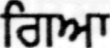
ਗਿਆ
